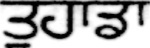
ਤੁਹਾਡਾ
